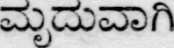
ಮೃದುವಾಗಿ
